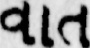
વાત
